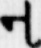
ન
